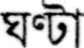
ঘণ্টা
